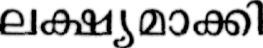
ലക്ഷ്യമാക്കി
